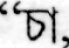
"চা,
